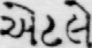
એટલે
